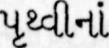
પૃથ્વીનાં
